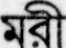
মরী
